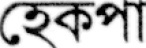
হেকপা
